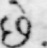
છે.
